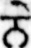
ਨੇ
